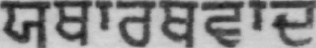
ਯਥਾਰਥਵਾਦ
